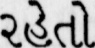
રહેતો
